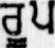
ਰੂਪ
